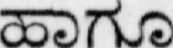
ಹಾಗೂ
